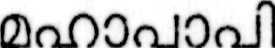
മഹാപാപി
